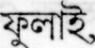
ফুলাই,
